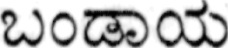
ಬಂಡಾಯ
